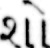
શો
